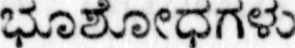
ಭೂಶೋಧಗಳು
